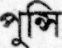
পুন্সি
